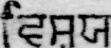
ਵਿਸ਼ਯ
